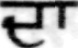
ਦਾ
